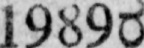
1989ರ
